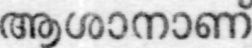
ആശാനാണ്
